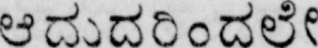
ಆದುದರಿಂದಲೇ
